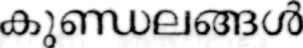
കുണ്ഡലങ്ങള്‍
